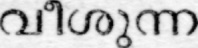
വീശുന്ന
